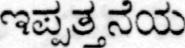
ಇಪ್ಪತ್ತನೆಯ
